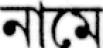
নামে
